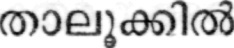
താലൂക്കില്‍
